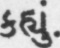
કહ્યું.
